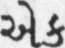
એક
